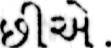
છીએ.
